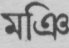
মঞি
